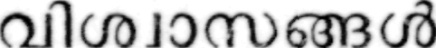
വിശ്വാസങ്ങള്‍
